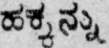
ಹಕ್ಕನ್ನು
